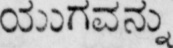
ಯುಗವನ್ನು
